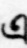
এ
